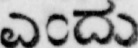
ಎಂದು
